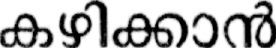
കഴിക്കാന്‍
